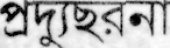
প্রদ্যুছরনা
